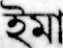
ইমা
